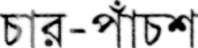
চার-পাঁচশ
